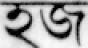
হজ
